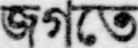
জগতে
